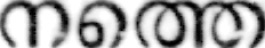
നത്തെ
